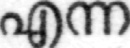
എന്ന
